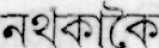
নথকাকৈ
